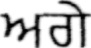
ਅਗੇ
